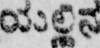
ಯಲ್ಲಿನ
